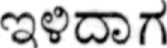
ಇಳಿದಾಗ
